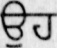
ਉਹ
